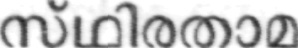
സ്ഥിരതാമ
